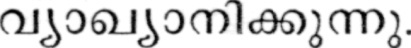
വ്യാഖ്യാനിക്കുന്നു.
